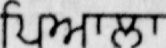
ਪਿਆਲਾ
